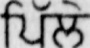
ਪਿੱਲੇ
